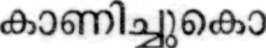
കാണിച്ചുകൊ
